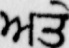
ਅਤੇ
